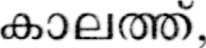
കാലത്ത്,
